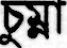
চুম্না
